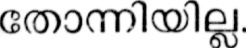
തോന്നിയില്ല.
